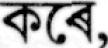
কৰে,
